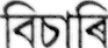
বিচাৰি
